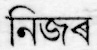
নিজৰ
